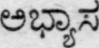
ಅಭ್ಯಾಸ
